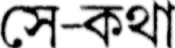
সে-কথা
